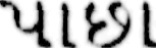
પાછા
